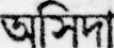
অসিদা
